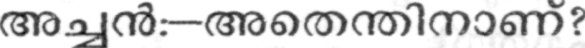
അച്ചന്‍:-അതെന്തിനാണ്?
